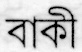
বাকী
